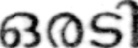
ഒരടി
